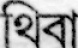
থিবা
